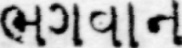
ભગવાન
